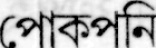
পোকপনি
